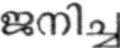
ജനിച്ച
